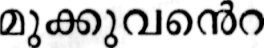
മുക്കുവന്റെ
